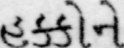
હક્કોને
